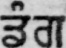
ਡੰਗ
